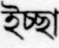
ইচ্ছা
